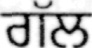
ਗੱਲ
